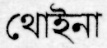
থোইনা
